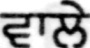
ਵਾਲੇ
